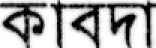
কাবদা
